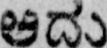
ಅದು
